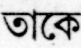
তাকে
